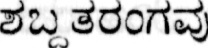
ಶಬ್ದತರಂಗವು
